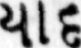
યાદ
